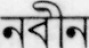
নবীন
